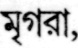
মৃগরা,
